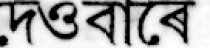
দেওবাৰে
